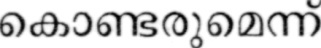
കൊണ്ടരുമെന്ന്
